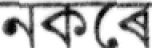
নকৰে
